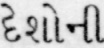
દેશોની
